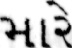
મારે
